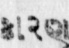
કારણ
